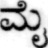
ಮೈ
